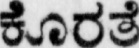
ಕೊರತೆ
